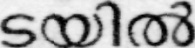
ടയില്‍
